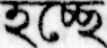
হচ্ছে
